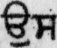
ਉਸ
